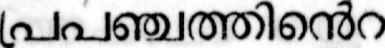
പ്രപഞ്ചത്തിന്റെ
